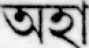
অহা
